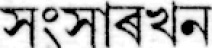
সংসাৰখন
